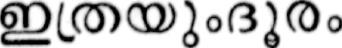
ഇത്രയുംദൂരം
